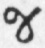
જ
